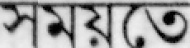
সময়তে
